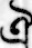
ঐ
